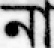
না
